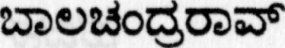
ಬಾಲಚಂದ್ರರಾವ್
